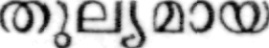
തുല്യമായ
